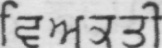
ਵਿਅਕਤੀ
